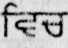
ਵਿਚ
